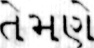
તેમણે
